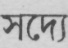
সদ্যে
